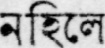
নহিলে
